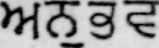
ਅਨੁਭਵ
